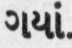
ગયાં.
